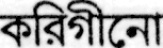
করিগীনো
